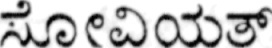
ಸೋವಿಯತ್
